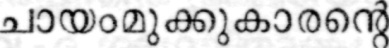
ചായംമുക്കുകാരന്റെ
